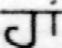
ਹਾਂ
